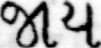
જાય
